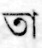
তা
